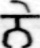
ਨੇ
